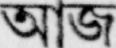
আজ
